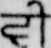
ਵੀ
